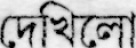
দেখিলো
